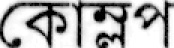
কোম্লপ
